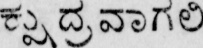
ಕ್ಷುದ್ರವಾಗಲಿ
